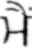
ਮੈਂ
